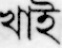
খাই
